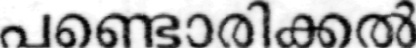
പണ്ടൊരിക്കല്‍
